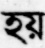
হয়
